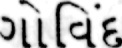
ગોવિંદ
